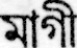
মাগী
